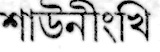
শাউনীংখি
